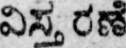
ವಿಸ್ತರಣೆ
